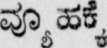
ವ್ಯೂಹಕ್ಕೆ
